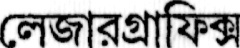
লেজারগ্রাফিক্স
